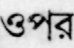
ওপর
